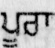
ਪੂਰਾ
